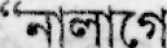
"নালাগে
